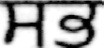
ਸਭ
